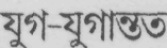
যুগ-যুগান্তত
